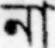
না
